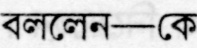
বললেন–কে
